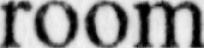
room
